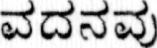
ವದನವು
